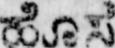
ಹೊಸ
